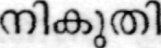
നികുതി
